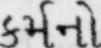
કર્મનો
